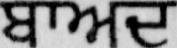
ਬਾਅਦ
